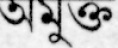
অমুক্ত
